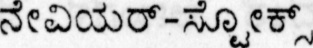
ನೇವಿಯರ್-ಸ್ಟೋಕ್ಸ್
